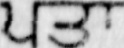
ਪਤਾ
